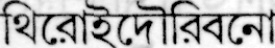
থিরোইদৌরিনো
